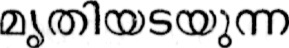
മൃതിയടയുന്ന
